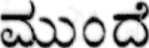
ಮುಂದೆ
